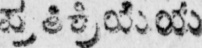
ಪ್ರತಿಕ್ರಿಯೆಯ
